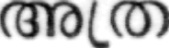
അത്ര
